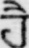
ਹੈ
